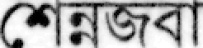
শেন্নজবা
